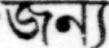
জন্য
